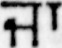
ਜਾ
